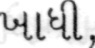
ખાધી,
